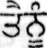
ਤੈਨੂੰ
